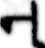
ન
